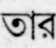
তার
